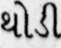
થોડી
